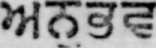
ਅਨੁਭਵ
